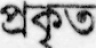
প্রকৃত
